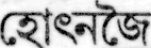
হোৎনজৈ
